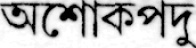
অশোকপদু
